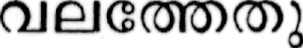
വലത്തേതു
